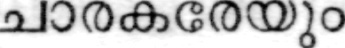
ചാരകരേയും
